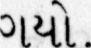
ગયો.
